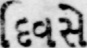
દિવસે
